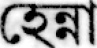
হেন্না
